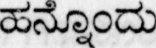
ಹನ್ನೊಂದು
